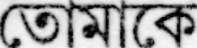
তোমাকে
